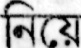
নিয়ে
